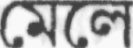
মেলে
